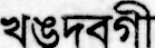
খঙদবগী
